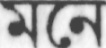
মনে
